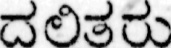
ದಲಿತರು
